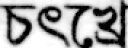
চৎখ্রে
